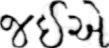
જઈએ
